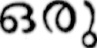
ഒരു
